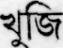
খুজি
